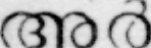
അര്‍
